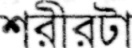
শরীরটা
